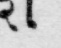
કરી
